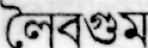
লৈবগুম
